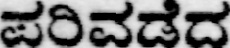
ಪರಿವಡೆದ
